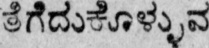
ತೆಗೆದುಕೊಳ್ಳುವ
